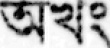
অখং
